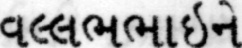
વલ્લભભાઈને
